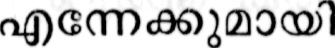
എന്നേക്കുമായി
